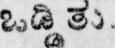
ಒಡ್ಡಿತು.
